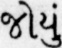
જોયું
